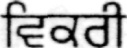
ਵਿਕਰੀ
